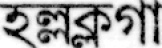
হল্লক্লগা
